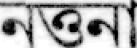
নত্তনা
